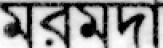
মরমদা
